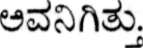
ಅವನಿಗಿತ್ತು.
